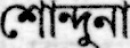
শোন্দুনা
